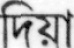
দিয়া
